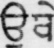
ਉਥੇ
